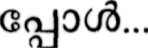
പ്പോള്‍...
